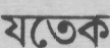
যতেক
